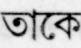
তাকে
